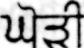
ਘੋੜੀ
